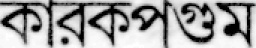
কারকপগুম
